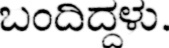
ಬಂದಿದ್ದಳು.
